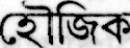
হৌজিক
